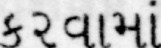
કરવામાં
